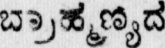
ಬ್ರಾಹ್ಮಣ್ಯದ
